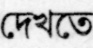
দেখতে
